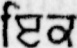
ਇਕ
